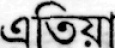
এতিয়া
